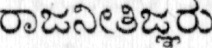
ರಾಜನೀತಿಜ್ಞರು
